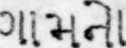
ગામનો
